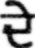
ਦੇ
